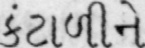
કંટાળીને
